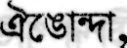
ঐঙোন্দা,
